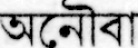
অনৌবা
